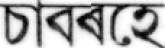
চাবৰহে
